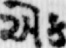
એક
